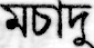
মচাদু
